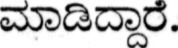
ಮಾಡಿದ್ದಾರೆ.
